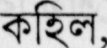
কহিল,
